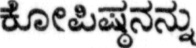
ಕೋಪಿಷ್ಠನನ್ನು
